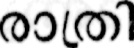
രാത്രി
